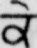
ਕੇ
